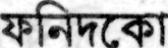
ফনিদকো
